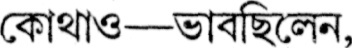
কোথাও-ভাবছিলেন,
